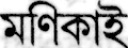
মণিকাই
